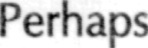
Perhaps
